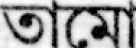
তামো
